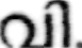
വി.
